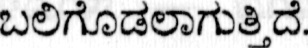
ಬಲಿಗೊಡಲಾಗುತ್ತಿದೆ.
